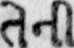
તેની
